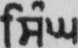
ਸਿੰਘ
